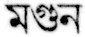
মগুন
